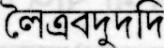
লৈত্রবদুদদি
